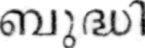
ബുദ്ധി
